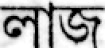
লাজ
